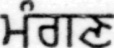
ਮੰਗਣ
